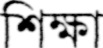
শিক্ষা
